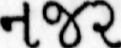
નજર
